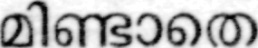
മിണ്ടാതെ
